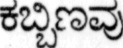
ಕಬ್ಬಿಣವು
